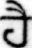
ਹੈ
